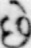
છે
